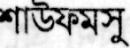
শাউফমসু
